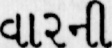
વારની
